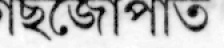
গছজোপাত
